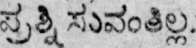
ಪ್ರಶ್ನಿಸುವಂತಿಲ್ಲ.
